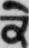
ਕੇ
